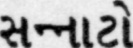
સન્નાટો
